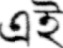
এই
